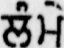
ਲੰਮੇ
